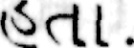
હતા.
